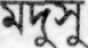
মদুসু
